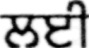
ਲਈ
